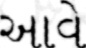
આવે
